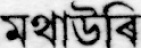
মথাউৰি
